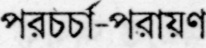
পরচর্চা-পরায়ণ
